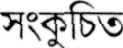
সংকুচিত
